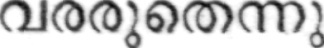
വരരുതെന്നു
